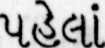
પહેલાં
